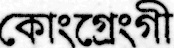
কোংগ্রেংগী
